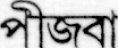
পীজবা
